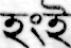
হংই
